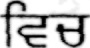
ਵਿਚ
